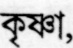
কৃষ্ণা,
